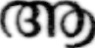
ആ
